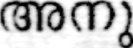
അനു
